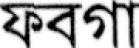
ফবদা
